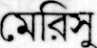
মেরিসু
